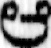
ಆ
